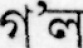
গ'ল
